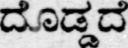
ದೊಡ್ಡದೆ
